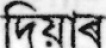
দিয়াৰ
